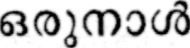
ഒരുനാള്‍
